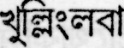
খুল্লিংলবা
